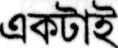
একটাই
